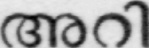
അറി
